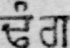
ਢੰਗ
